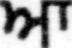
ਆ
